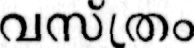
വസ്ത്രം
